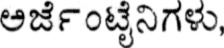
ಅರ್ಜೆಂಟೈನಿಗಳು,
